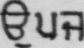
ਉਪਜ
